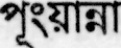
পূংয়ান্না
